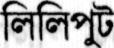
লিলিপুট
